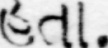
હતા.
